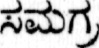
ಸಮಗ್ರ
